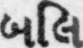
બલિ
